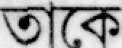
তাকে
